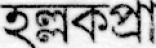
হল্লকপ্রা
